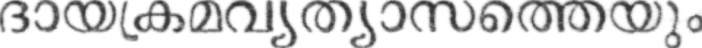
ദായക്രമവ്യത്യാസത്തെയും
